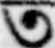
ত
